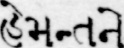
હેમન્તને
